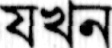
যখন
